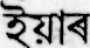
ইয়াৰ
